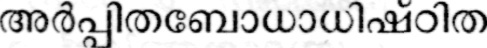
അര്‍പ്പിതബോധാധിഷ്ഠിത
